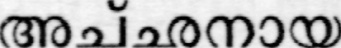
അച്ഛനായ
